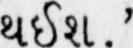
થઈશ.'
